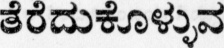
ತೆರೆದುಕೊಳ್ಳುವ
